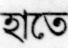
হাতে
